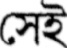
সেই
